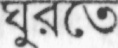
ঘুরতে
